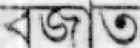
বজাত
